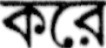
করে
